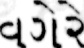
વગેરે
